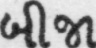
બીજા
